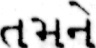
તમને
